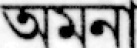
অমনা
